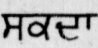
ਸਕਦਾ
